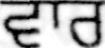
ਵਾਰ
